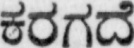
ಕರಗದೆ
